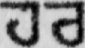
ਹਰ
